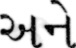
અને
